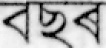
বছৰ
